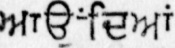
ਆਉਂਦਿਆਂ
